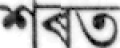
শৰত
